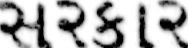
સરકાર
